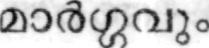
മാര്‍ഗ്ഗവും
